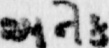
અનેક
